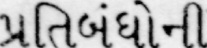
પ્રતિબંધોની
